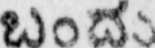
ಬಂದು
